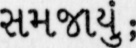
સમજાયું;
